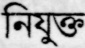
নিযুক্ত
